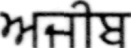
ਅਜੀਬ
